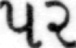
પર
